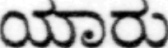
ಯಾರು
